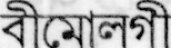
বীমোলগী
